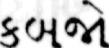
કબજો
